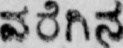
ವರೆಗಿನ
